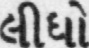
લીધો
